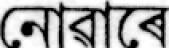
নোৱাৰে
